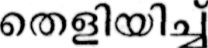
തെളിയിച്ച്
